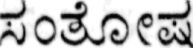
ಸಂತೋಷ
